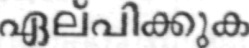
ഏല്പിക്കുക
